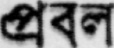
প্রবল
